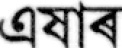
এষাৰ
